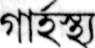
গার্হস্থ্য
